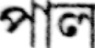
পাল
